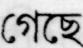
গেছে
